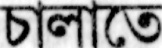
চালাতে
